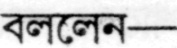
বললেন–
